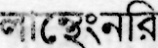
লান্থেংনরি
